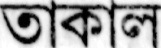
তাকাল
